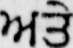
ਅਤੇ
